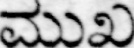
ಮುಖ
